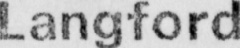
Langford
